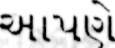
આપણે
